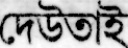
দেউতাই
